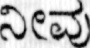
ನೀವು
